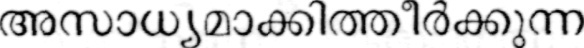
അസാധ്യമാക്കിത്തീര്‍ക്കുന്ന
